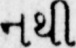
નથી
